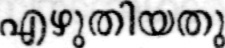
എഴുതിയതു
